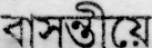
বাসন্তীয়ে
